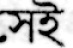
সেই
